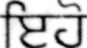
ਇਹੋ
